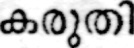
കരുതി
